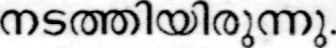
നടത്തിയിരുന്നു.
